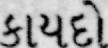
કાયદો
